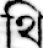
থি
